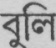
বুলি
